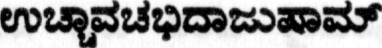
ಉಚ್ಚಾವಚಭಿದಾಜುಷಾಮ್
